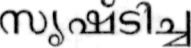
സൃഷ്ടിച്ച
